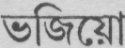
ভজিয়ো
